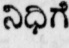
ನಿಧಿಗೆ
